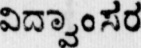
ವಿದ್ವಾಂಸರ
